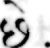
છે.
